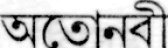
অতোনবী
